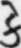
કે
